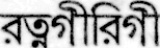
রত্নগীরিগী
